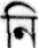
নি
